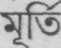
মূর্তি
